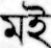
মই
